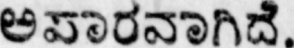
ಅಪಾರವಾಗಿದೆ.
